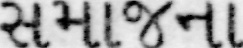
સમાજના
